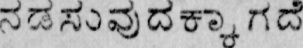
ನಡಸುವುದಕ್ಕಾಗದೆ
